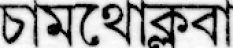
চামথোক্লবা
